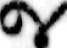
જ
